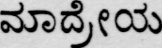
ಮಾದ್ರೇಯ
